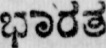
ಭಾರತ
